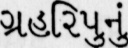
ગ્રહરિપુનું
